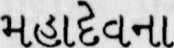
મહાદેવના
